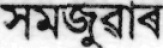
সমজুৱাৰ
